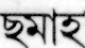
ছমাহ
